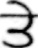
ਤੇ
